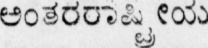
ಅಂತರರಾಷ್ಟ್ರೀಯ
